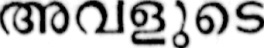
അവളുടെ
